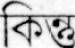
কিন্তু
